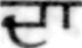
ਦਾ
